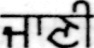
ਜਾਣੀ
